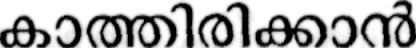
കാത്തിരിക്കാന്‍
